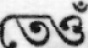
তেওঁ
